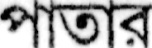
পাতার
